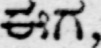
ಈಗ,
